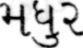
મધુર
